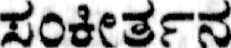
ಸಂಕೀರ್ತನ
